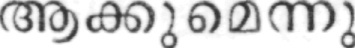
ആക്കുമെന്നു
